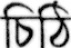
চিঠি
